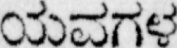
ಯವಗಳ
